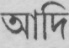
আদি
